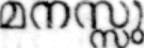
മനസ്സു
